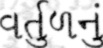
વર્તુળનું
